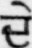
ਦੇ
